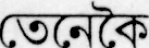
তেনেকৈ
